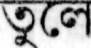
তুলে
